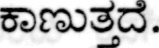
ಕಾಣುತ್ತದೆ.
